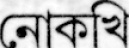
নোকখি
